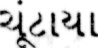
ચૂંટાયા
